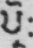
ਪ੍ਰੋ:
